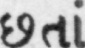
છતાં
